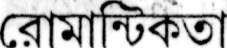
রোমান্টিকতা
